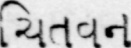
ચિતવન
